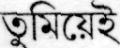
তুমিয়েই
